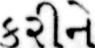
કરીને
